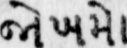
જોખમો
